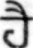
ਹੈ
